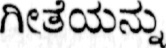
ಗೀತೆಯನ್ನು
